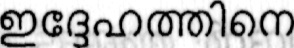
ഇദ്ദേഹത്തിനെ
